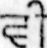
ਵੀ
